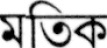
মতিক
